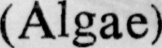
(Algae)
